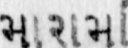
મારામાં
